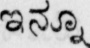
ಇನ್ನೂ
